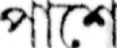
পাশে
